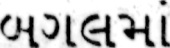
બગલમાં
